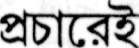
প্রচারেই
